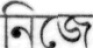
নিজে
